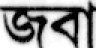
জবা
